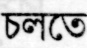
চলতে
